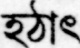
হঠাৎ
